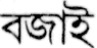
বজাই
